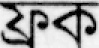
ফ্রক
